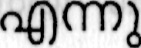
എന്നു
